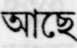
আছে
